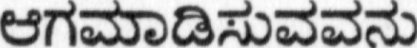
ಆಗಮಾಡಿಸುವವನು
